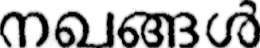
നഖങ്ങള്‍
